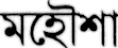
মহৌশা
